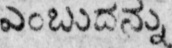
ಎಂಬುದನ್ನು
